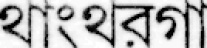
থাংথরগা
